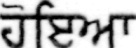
ਹੋਇਆ
